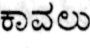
ಕಾವಲು
